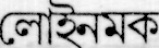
লোইনমক
